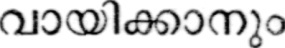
വായിക്കാനും
